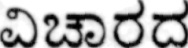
ವಿಚಾರದ
